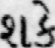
શકે
